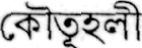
কৌতূহলী
